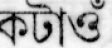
কটাওঁ
